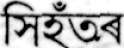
সিহঁতৰ
